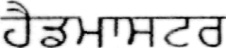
ਹੈਡਮਾਸਟਰ
